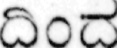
ದಿಂದ
